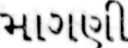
માગણી
